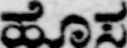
ಹೊಸ
